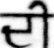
ਦੀ
